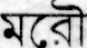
মরৌ
